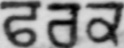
ਫਰਕ
